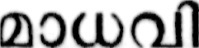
മാധവി
